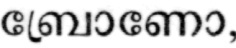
ബ്രോണോ,
